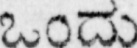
ಒಂದು
